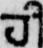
ਹੀ
